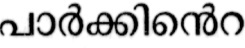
പാര്‍ക്കിന്റെ
